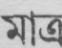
মাত্ৰ
